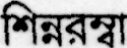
শিন্নরম্বা
